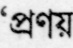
‘প্রণয়
